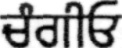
ਚੰਗੀਓ
